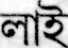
লাই
